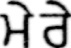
ਮੇਰੇ
